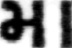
મા
